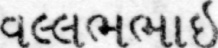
વલ્લભભાઈ
